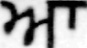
ਆ
